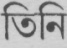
তিনি
